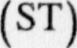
(ST)
